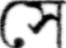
সে
